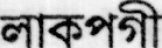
লাকপগী
